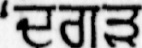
'ਦਗੜ
